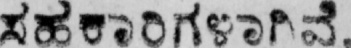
ಸಹಕಾರಿಗಳಾಗಿವೆ.
